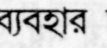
ব্যবহার
